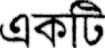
একটি
